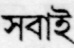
সবাই
